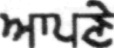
ਆਪਣੇ
